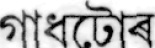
গাধটোৰ
